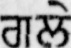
ਗਲੇ
